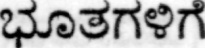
ಭೂತಗಳಿಗೆ
